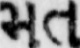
મત
